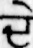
ਦੇ
